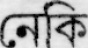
নেকি
